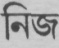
নিজ
